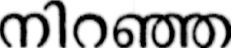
നിറഞ്ഞ
